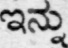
ಇನ್ನು
